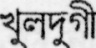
খুলদুগী
